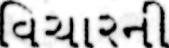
વિચારની
